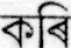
কৰি
